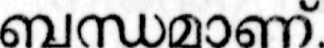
ബന്ധമാണ്.
